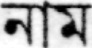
নাম
